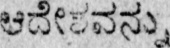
ಆದೇಶವನ್ನು
